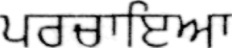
ਪਰਚਾਇਆ
